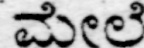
ಮೇಲೆ
